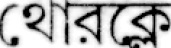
থোরক্লে
